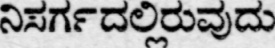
ನಿಸರ್ಗದಲ್ಲಿರುವುದು
